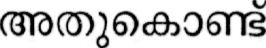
അതുകൊണ്ട്
